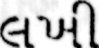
લખી
